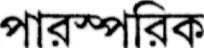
পারস্পরিক
